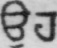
ਉਹ
